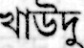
খাউদু
